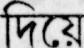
দিয়ে
